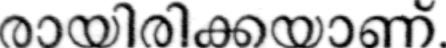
രായിരിക്കയാണ്.
